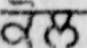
ਕੋਲ
